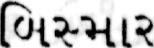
બિસ્માર
